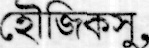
হৌজিকসু,
